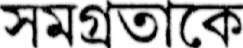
সমগ্রতাকে
